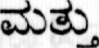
ಮತ್ತು
